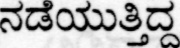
ನಡೆಯುತ್ತಿದ್ದ
